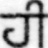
ਹੀ
